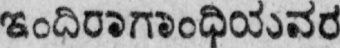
ಇಂದಿರಾಗಾಂಧಿಯವರ
